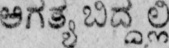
ಅಗತ್ಯಬಿದ್ದಲ್ಲಿ
